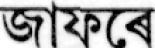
জাফৰে
